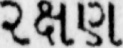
રક્ષણ
